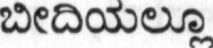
ಬೀದಿಯಲ್ಲೂ
